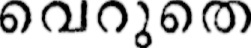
വെറുതെ
